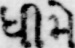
ધીમે
